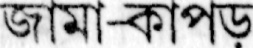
জামা-কাপড়
